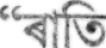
"ৰাতি
